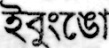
ইবুংঙো
